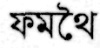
ফমথৈ
